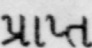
પ્રાપ્ત
